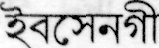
ইবসেনগী
